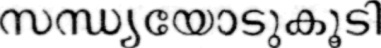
സന്ധ്യയോടുകൂടി
